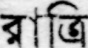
রাত্রি
